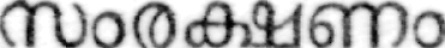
സംരക്ഷണം
